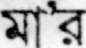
মা’র
